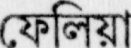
ফেলিয়া
